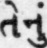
તેનું
